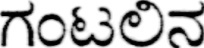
ಗಂಟಲಿನ
